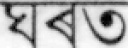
ঘৰত
